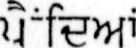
ਪੈਂਦਿਆਂ
